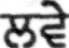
ਲਵੇ
